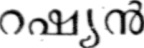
റഷ്യന്‍
